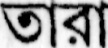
তারা
